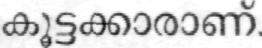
കൂട്ടുക്കാരാണ്.
